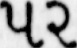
પર
